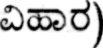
ವಿಹಾರ)
